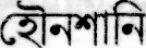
হৌনশানি
